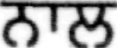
ਨਾਲ
